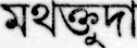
মথক্তুদা
